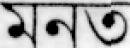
মনত
